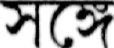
সঙ্গে
